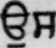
ਉਸ
